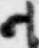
ન
